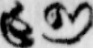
હજી
